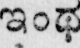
ಇಂಥ
